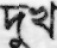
দুখ
